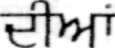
ਦੀਆਂ
